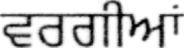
ਵਰਗੀਆਂ
